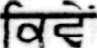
ਕਿਵੇਂ
